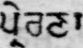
ਪ੍ਰੇਰਣਾ
